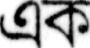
এক
